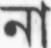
না
